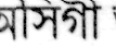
অসিগী
